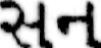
સન
